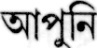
আপুনি
